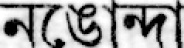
নঙোন্দা
